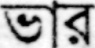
ভার
